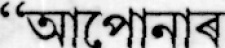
"আপোনাৰ
